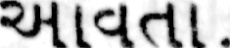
આવતા.
